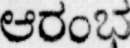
ಆರಂಭ
